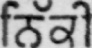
ਨਿੱਕੀ
